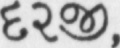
દરજી,
